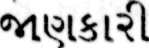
જાણકારી
